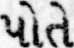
પોતે
